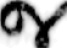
જ
